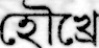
হৌখ্রে
